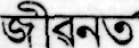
জীৱনত
